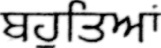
ਬਹੁਤਿਆਂ
